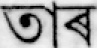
তাৰ
